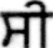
ਸੀ
